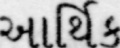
આર્થિક
